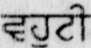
ਵਹੁਟੀ
